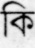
কি
